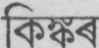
কিঙ্কৰ
